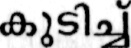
കുടിച്ച്
